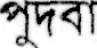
পুদবা
